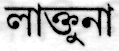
লাক্তুনা
